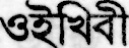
ওইখিবী
